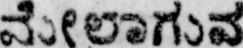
ಮೇಲಾಗುವ
